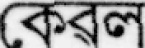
কেৱল
